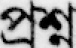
প্রশ্ন
